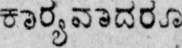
ಕಾರ್‍ಯವಾದರೂ
